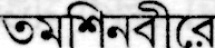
তমশিনবীরে
